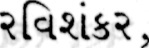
રવિશંકર,
